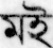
মই
